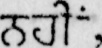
ਨਹੀਂ,
